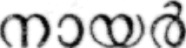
നായര്‍
